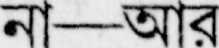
না-আর
